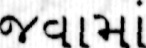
જવામાં
